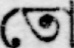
তো
